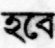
হবে
